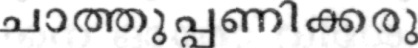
ചാത്തുപ്പണിക്കരു
